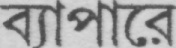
ব্যাপারে
